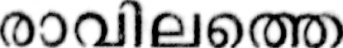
രാവിലത്തെ
